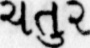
ચતુર
